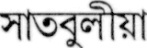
সাতবুলীয়া
